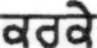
ਕਰਕੇ
